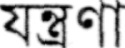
যন্ত্রণা
